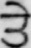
ਤੇ
